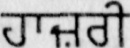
ਹਾਜ਼ਰੀ
